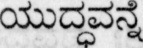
ಯುದ್ಧವನ್ನೆ
